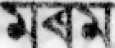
মৰম
